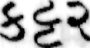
કટ્ટર
